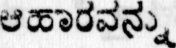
ಆಹಾರವನ್ನು
